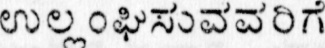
ಉಲ್ಲಂಘಿಸುವವರಿಗೆ
